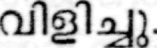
വിളിച്ചു.
